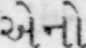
એનો
